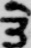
ਤੇ
